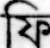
ফি
